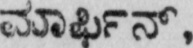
ಮಾರ್ಫಿನ್,
